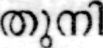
തുനി
